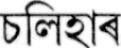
চলিহাৰ
